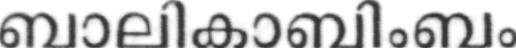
ബാലികാബിംബം
